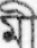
মী
